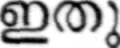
ഇതു
